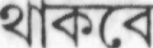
থাকবে
